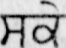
ਸਕੇ
